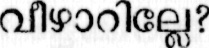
വീഴാറില്ലേ?
